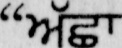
''ਅੱਛਾ
